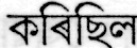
কৰিছিল
